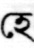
হে
